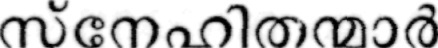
സ്നേഹിതന്മാര്‍
